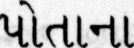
પોતાના
